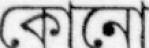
কোনো
